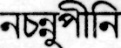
নচন্নুপীনি
